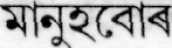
মানুহবোৰ
